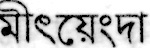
মীৎয়েংদা
